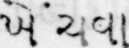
ખેંચાવા
